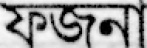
ফজনা
